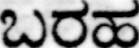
ಬರಹ
